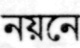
নয়নে
